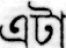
এটা
